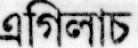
এগিলাচ
